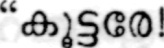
“കൂട്ടരേ!
